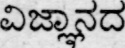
ವಿಜ್ಞಾನದ
